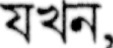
যখন,
